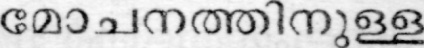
മോചനത്തിനുള്ള
